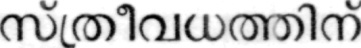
സ്ത്രീവധത്തിന്
